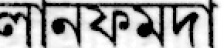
লানফমদা
